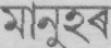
মানুহৰ
